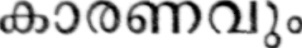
കാരണവും
